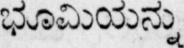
ಭೂಮಿಯನ್ನು
